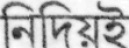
নিদিয়ই
